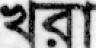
খরা
